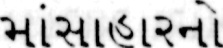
માંસાહારનો
